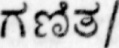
ಗಣಿತ/
